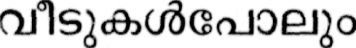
വീടുകള്‍പോലും
